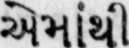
એમાંથી
